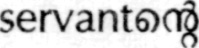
servantന്റെ
